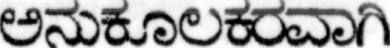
ಅನುಕೂಲಕರವಾಗಿ
